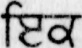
ਇਕ
